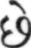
છે
